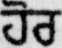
ਹੋਰ
